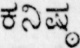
ಕನಿಷ್ಠ
